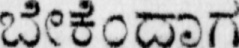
ಬೇಕೆಂದಾಗ
